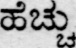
ಹೆಚ್ಚು
